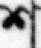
শ
